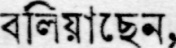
বলিয়াছেন,
